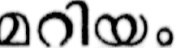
മറിയം
